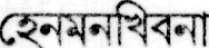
হেনমনখিবনা
